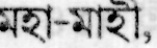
মহা-মাহী,
